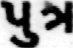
પુત્ર
